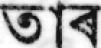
তাৰ
